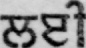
ਲਈ
